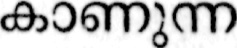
കാണുന്ന
